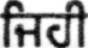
ਜਿਹੀ
